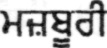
ਮਜ਼ਬੂਰੀ
